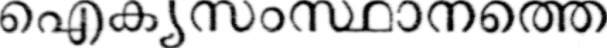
ഐക്യസംസ്ഥാനത്തെ
